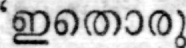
‘ഇതൊരു
